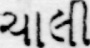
ચાલી
